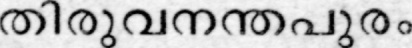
തിരുവനന്തപുരം
